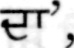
ਦਾ',
